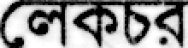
লেকচর
